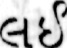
લઈ
